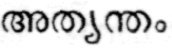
അത്യന്തം
